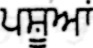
ਪਸ਼ੂਆਂ
